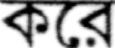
করে
